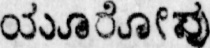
ಯೂರೋಪು
